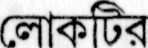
লোকটির
